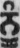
ਨੂੰ
